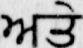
ਅਤੇ
